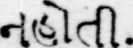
નહોતી.
